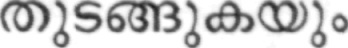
തുടങ്ങുകയും
